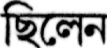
ছিলেন
